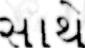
સાથે
